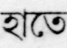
হাতে
